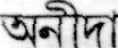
অনীদো
